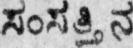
ಸಂಸತ್ತಿನ
